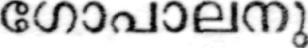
ഗോപാലനു
